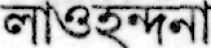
লাওহন্দনা
